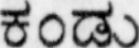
ಕಂಡು
